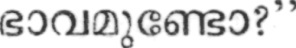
ഭാവമുണ്ടോ?"
